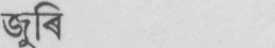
জুৰি
